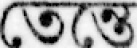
তেন্তে
